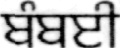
ਬੰਬਈ
